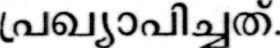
പ്രഖ്യാപിച്ചത്.
